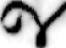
જ
